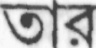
তার
